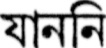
যাননি
